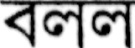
বলল
